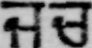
ਜਚ
